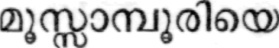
മൂസ്സാമ്പൂരിയെ
